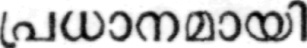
പ്രധാനമായി
